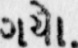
ગયો.
